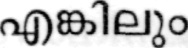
എങ്കിലും
